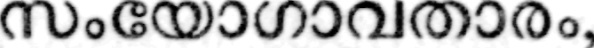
സംയോഗാവതാരം,
